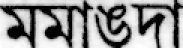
মমাঙদা
